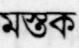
মস্তক
